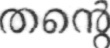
തന്റെ
